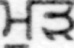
ਮੁੜ
